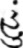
હું
